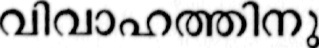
വിവാഹത്തിനു
